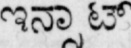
ಇನ್ಸಾಟ್
